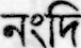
নংদি
